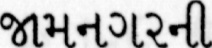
જામનગરની
